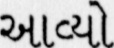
આવ્યો
